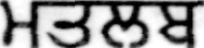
ਮਤਲਬ
